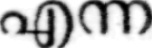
എന്ന
